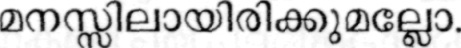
മനസ്സിലായിരിക്കുമല്ലോ.
